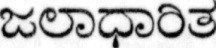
ಜಲಾಧಾರಿತ
